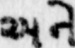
અને
